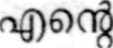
എന്റെ
